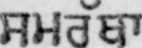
ਸਮਰੱਥਾ
